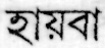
হায়বা
